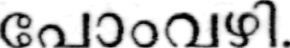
പോംവഴി.
